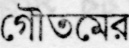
গৌতমের
